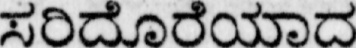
ಸರಿದೊರೆಯಾದ
